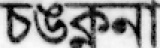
চঙক্ননা
